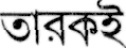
তারকই
